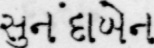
સુનંદાબેન
